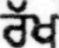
ਰੱਖ
